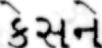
કેસને
